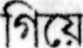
গিয়ে
